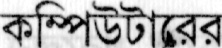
কম্পিউটারের
